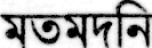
মতমদনি
